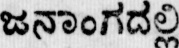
ಜನಾಂಗದಲ್ಲಿ
